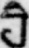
ਹੈ
